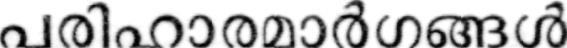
പരിഹാരമാര്‍ഗങ്ങള്‍
